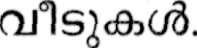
വീടുകള്‍.
